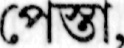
পেস্তা,
